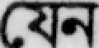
যেন
